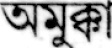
অমুক্কা
